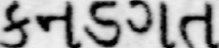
કનડગત
